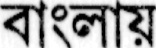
বাংলায়
